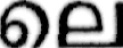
ലെ
